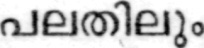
പലതിലും
